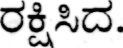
ರಕ್ಷಿಸಿದ.
